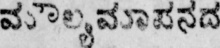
ಮೌಲ್ಯಮಾಪನದ
